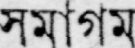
সমাগম
